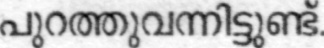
പുറത്തുവന്നിട്ടുണ്ട്.
